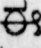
ಈ
